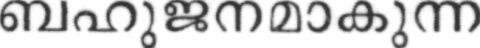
ബഹുജനമാകുന്ന
